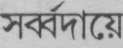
সৰ্ব্বদায়ে
